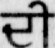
ਦੀ
